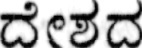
ದೇಶದ
